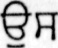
ਉਸ
